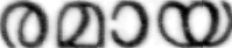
രമായ
